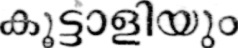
കൂട്ടാളിയും
